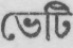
ভেটি
